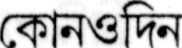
কোনওদিন
